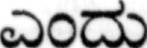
ಎಂದು
